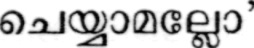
ചെയ്യാമല്ലോ’
